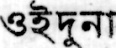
ওইদুনা
